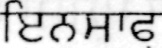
ਇਨਸਾਫ਼
